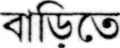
বাড়িতে
